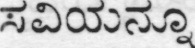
ಸವಿಯನ್ನೂ
